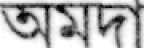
অমদা
